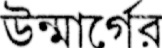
উন্মার্গের
